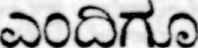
ಎಂದಿಗೂ
